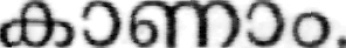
കാണാം.
